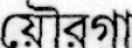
য়ৌরগা
